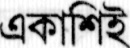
একাশিই
